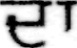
ਦਾ
